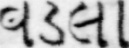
વડલા
